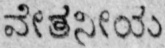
ವೇತನೀಯ
